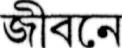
জীবনে
